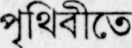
পৃথিবীতে
